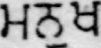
ਮਨੁਖ
